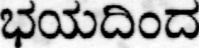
ಭಯದಿಂದ
